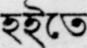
হইতে
